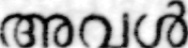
അവള്‍
